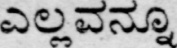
ಎಲ್ಲವನ್ನೂ
